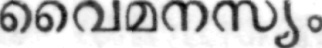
വൈമനസ്യം
